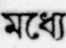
মধ্যে
